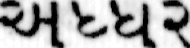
અધ્ધર
